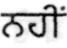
ਨਹੀਂ
